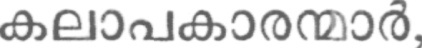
കലാപകാരന്മാര്‍,
